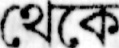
থেকে
